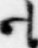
ન
